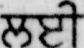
ਲਈ
